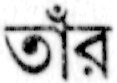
তার
